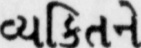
વ્યકિતને
